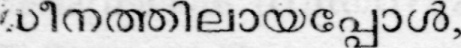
ധീനത്തിലായപ്പോള്‍,
